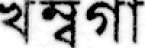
খম্বগা
